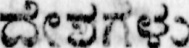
ದೇಶಗಳು
